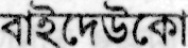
বাইদেউকো
